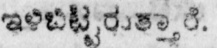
ಇಳಿಬಿಟ್ಟಿರುತ್ತಾರೆ.
